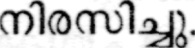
നിരസിച്ചു.
